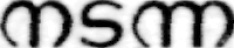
നടന്ന
